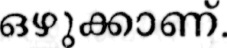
ഒഴുക്കാണ്.
